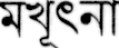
মখূৎনা
